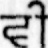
ਵੀ
